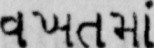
વખતમાં
